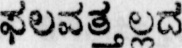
ಫಲವತ್ತಲ್ಲದ
